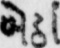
બેઠાં
